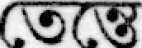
তেন্তে
